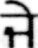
ਜੇ
